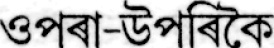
ওপৰা-উপৰিকৈ
